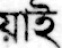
য়াই
